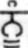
ਨੂੰ
